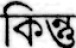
কিন্তু
